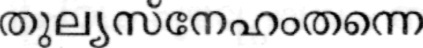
തുല്യസ്നേഹംതന്നെ
